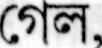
গেল,
